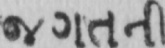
જગતની
